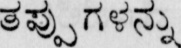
ತಪ್ಪುಗಳನ್ನು
